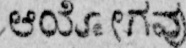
ಆಯೋಗವು
